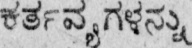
ಕರ್ತವ್ಯಗಳನ್ನು
